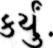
કર્યું.
